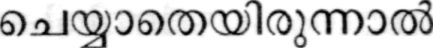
ചെയ്യാതെയിരുന്നാല്‍
